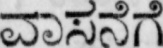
ವಾಸನೆಗೆ
